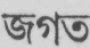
জগত
